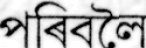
পৰিবলৈ
